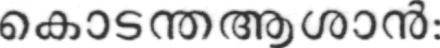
കൊടന്തആശാന്‍:
